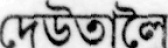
দেউতালৈ
